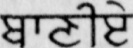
ਬਾਣੀਏ
